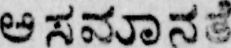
ಅಸಮಾನತೆ
